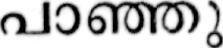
പാഞ്ഞു
